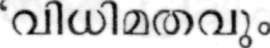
'വിധിമതവും
